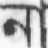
না
